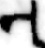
ન
